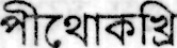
পীথোকখ্রি
